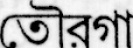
তৌরগা
